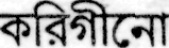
করিগীনো
